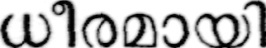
ധീരമായി
